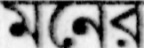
মনের
